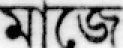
মাজে
